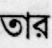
তার
